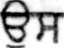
ਉਸ
